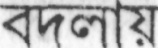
বদলায়
